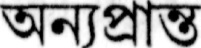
অন্যপ্রান্ত
